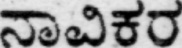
ನಾವಿಕರ
